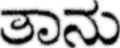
ತಾನು
